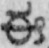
ಈ
